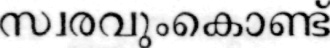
സ്വരവുംകൊണ്ട്
